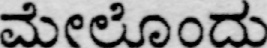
ಮೇಲೊಂದು
